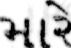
મારે
